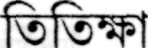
তিতিক্ষা
